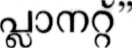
പ്ളാനറ്റ്"
